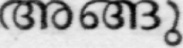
അങ്ങു
